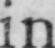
in
